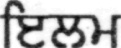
ਇਲਮ
